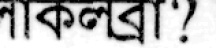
লাকলব্রা?
